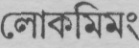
লোকমিমং
